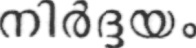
നിര്‍ദ്ദയം
